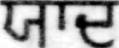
ਯਾਦ
